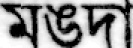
মঙদা
